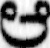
ಆ
